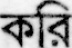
করি
